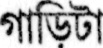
গাড়িটা
